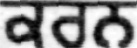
ਕਰਨ
